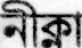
নীক্না
